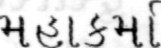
મહાકર્મા
